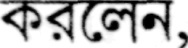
করলেন,
